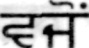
ਵਜੋਂ
